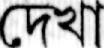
দেখা
